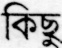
কিছু
